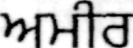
ਅਮੀਰ
